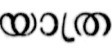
യാത്ര
